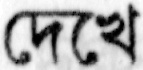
দেখে
